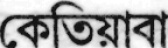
কেতিয়াবা
